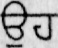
ਉਹ
